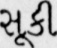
સૂકી
